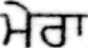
ਮੇਰਾ
